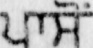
ਪਾਸੋਂ
